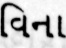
વિના
